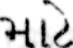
માટે
